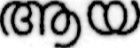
ആയ
